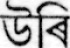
উৰি
